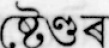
ষ্টেণ্ডৰ
